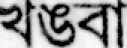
খঙবা
